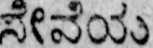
ಸೇವೆಯ
